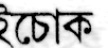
ইচোক
